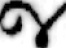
જ
